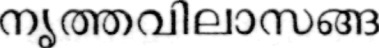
നൃത്തവിലാസങ്ങ
